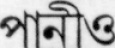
পানীও
